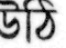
উঠি
